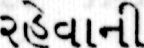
રહેવાની
